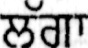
ਲੱਗਾ
